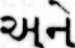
અને
